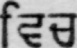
ਵਿਚ
